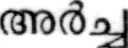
അര്‍ച്ച
